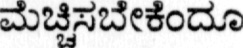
ಮೆಚ್ಚಿಸಬೇಕೆಂದೂ
